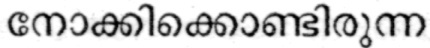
നോക്കിക്കൊണ്ടിരുന്ന
